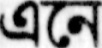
এনে
